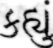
કહ્યું
